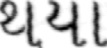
થયા
